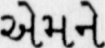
એમને
